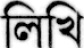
লিখি
